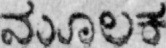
ಮೂಲಕ
